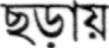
ছড়ায়
